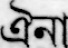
ঐনা
